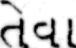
તેવા
